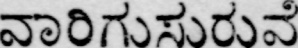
ವಾರಿಗುಸುರುವೆ
